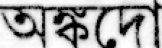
অঙ্কদো
